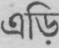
এড়ি
